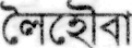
লৈহৌবা
